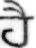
ਹੈ
